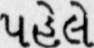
પહેલે
